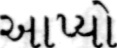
આપ્યો
